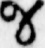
જ
